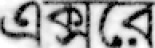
এক্সরে
